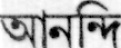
আনন্দি
